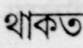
থাকত
